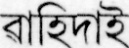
ৱাহিদাই
